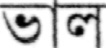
ভাল
